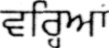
ਵਰ੍ਹਿਆਂ
